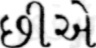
છીએ
